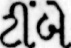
ટીંબે
